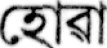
হোৱা
